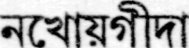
নখোয়গীদা
